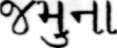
જમુના
